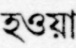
হওয়া
